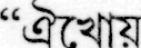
“ঐখোয়
